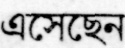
এসেছেন
